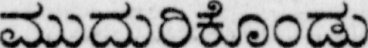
ಮುದುರಿಕೊಂಡು
